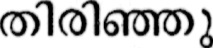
തിരിഞ്ഞു
